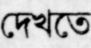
দেখতে
